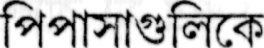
পিপাসাগুলিকে
